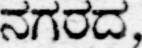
ನಗರದ,
